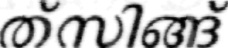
ത്സിങ്ങ്
